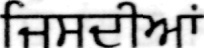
ਜਿਸਦੀਆਂ
